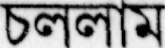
চললাম
